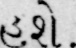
હશે.
